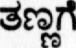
ತಣ್ಣಗೆ
